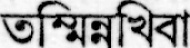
তম্মিন্নখিবা
